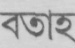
বতাহ
